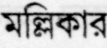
মল্লিকার
